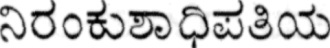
ನಿರಂಕುಶಾಧಿಪತಿಯ
